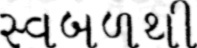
સ્વબળથી
